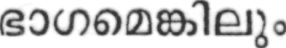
ഭാഗമെങ്കിലും
